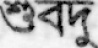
শুবদু
